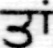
ਤਾਂ
